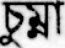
চুম্না
